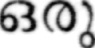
ഒരു
